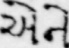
એને
